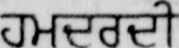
ਹਮਦਰਦੀ
